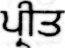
ਪ੍ਰੀਤ
